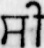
ਸੀ
